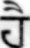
ਹੈ
